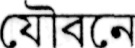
যৌবনে
